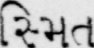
સ્મિત
